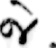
જે.
